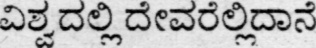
ವಿಶ್ವದಲ್ಲಿದೇವರೆಲ್ಲಿದಾನೆ
